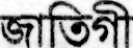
জাতিগী
